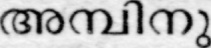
അമ്പിനു
